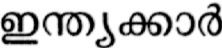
ഇന്ത്യക്കാര്‍
